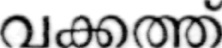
വക്കത്ത്
